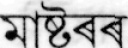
মাষ্টৰৰ
